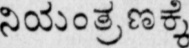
ನಿಯಂತ್ರಣಕ್ಕೆ
